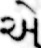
એ
